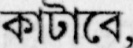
কাটাবে,
